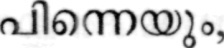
പിന്നെയും,
